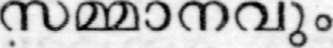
സമ്മാനവും
